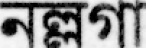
নল্লগা
